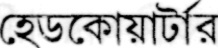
হেডকোয়ার্টার
